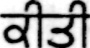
ਕੀਤੀ
